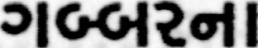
ગબ્બરના
